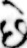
છે
